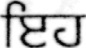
ਇਹ
